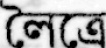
লৈত্রে
